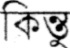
কিন্তু
